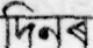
দিনৰ
